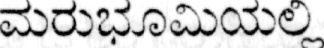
ಮರುಭೂಮಿಯಲ್ಲಿ
